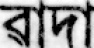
ৱাদা
